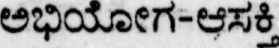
ಅಭಿಯೋಗ-ಆಸಕ್ತಿ
